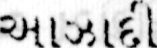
આઝાદી
